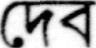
দেব
